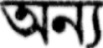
অন্য
